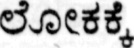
ಲೋಕಕ್ಕೆ
